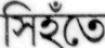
সিহঁতে
